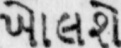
ખોલશે
